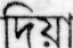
দিয়া
